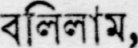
বলিলাম,
